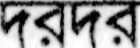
দরদর
